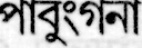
পাবুংগনা
